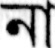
না
